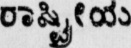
ರಾಷ್ಟ್ರೀಯ
